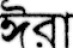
ঈরা
